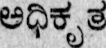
ಅಧಿಕೃತ
